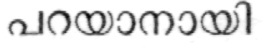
പറയാനായി
